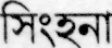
সিংহনা
